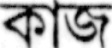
কাজ
